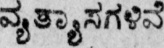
ವ್ಯತ್ಯಾಸಗಳಿವೆ
